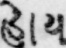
હોય
